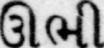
ઊભી
